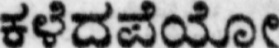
ಕಳೆದಪೆಯೋ
